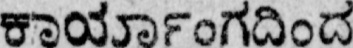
ಕಾರ್ಯಾಂಗದಿಂದ
